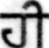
ਹੀ
